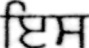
ਇਸ
